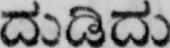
ದುಡಿದು
